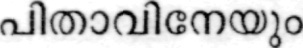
പിതാവിനേയും
